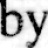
by
